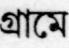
গ্রামে
